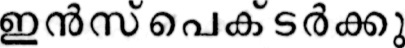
ഇന്‍സ്പെക്ടര്‍ക്കു
